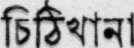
চিঠিখানা
